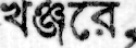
খঞ্জরে,
